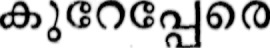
കുറേപ്പേരെ
